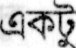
একটু
